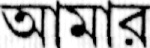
আমার
